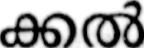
ക്കല്‍
